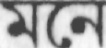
মনে
